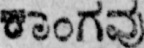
ಕಾಂಗವು
